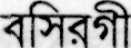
বসিরগী
